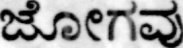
ಜೋಗವು
